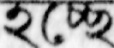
হচ্ছে
